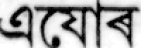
এযোৰ
